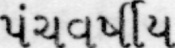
પંચવર્ષીય
